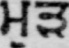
ਮੁੜ
